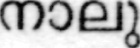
നാലു
